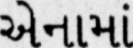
એનામાં
